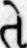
તે
